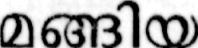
മങ്ങിയ
